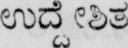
ಉದ್ದೇಶಿತ
